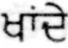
ਖਾਂਦੇ
